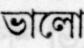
ভালো
